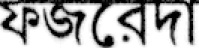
ফজরেদা
